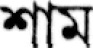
শাম
